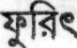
ফুরিৎ
